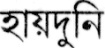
হায়দুনি
